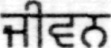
ਜੀਵਨ
